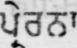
ਪ੍ਰੇਰਨਾ
